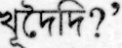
খূদৈদি?’
